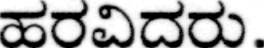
ಹರವಿದರು.
